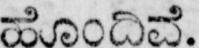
ಹೊಂದಿವೆ.
